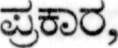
ಪ್ರಕಾರ,
